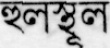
হুলস্হূল
